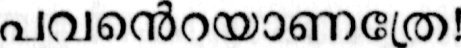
പവന്റെയാണത്രേ!
